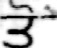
ਤੋਂ
